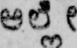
ಅಲ್ಲೇ
